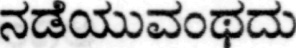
ನಡೆಯುವಂಥದು
